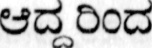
ಆದ್ದರಿಂದ
